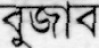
বুজাব
